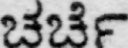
ಚರ್ಚೆ
